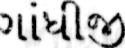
ગાંધીજી
